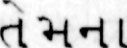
તેમના
